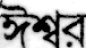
ঈশ্বর
